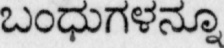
ಬಂಧುಗಳನ್ನೂ
